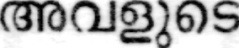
അവളുടെ
